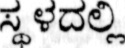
ಸ್ಥಳದಲ್ಲಿ
